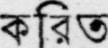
করিত
